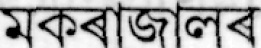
মকৰাজালৰ
